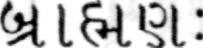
બ્રાહ્મણઃ
